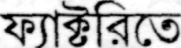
ফ্যাক্টরিতে
